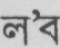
ল'ব
